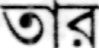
তার
